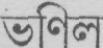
ভণিল
